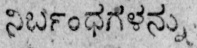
ನಿರ್ಬಂಧಗಳನ್ನು
